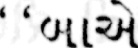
"બાએ
